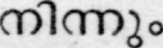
നിന്നും
